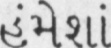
હંમેશાં
